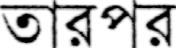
তারপর
